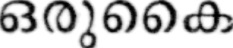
ഒരുകൈ
